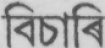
বিচাৰি
